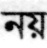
নয়
